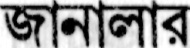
জানালার
